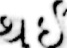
થઈ
